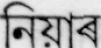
নিয়াৰ
